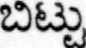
ಬಿಟ್ಟು
